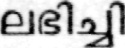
ലഭിച്ചി
